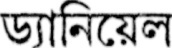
ড্যানিয়েল
